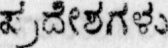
ಪ್ರದೇಶಗಳು
